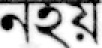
নহয়
